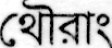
থৌরাং
